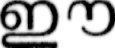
ഈ
